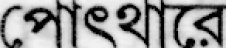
পোৎথারে
